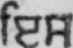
ਇਸ
